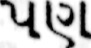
પણ
